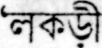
‘লকড়ী
